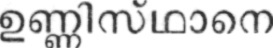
ഉണ്ണിസ്ഥാനെ
